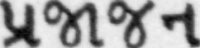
પ્રજાજન
